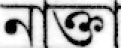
নাক্তা
